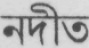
নদীত
